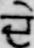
ਦੇ
